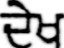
ਦੇਖ
